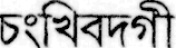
চংখিবদগী
